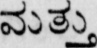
ಮತ್ತು
